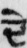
ਦੇ
